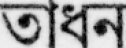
তাধন
